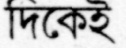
দিকেই
